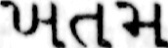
ખતમ
